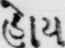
હોય
